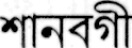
শানবগী
